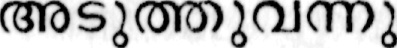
അടുത്തുവന്നു
